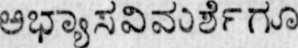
ಅಭ್ಯಾಸವಿಮರ್ಶೆಗೂ
